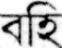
বহি
